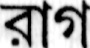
রাগ
